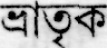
ভ্রাতৃক
